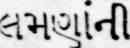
લમણાંની
